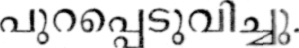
പുറപ്പെടുവിച്ചു.
